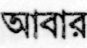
আবার
